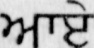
ਆਏ
